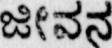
ಜೀವನ
